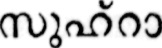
സുഹ്റാ
